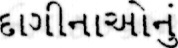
દાગીનાઓનું
